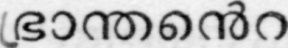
ഭ്രാന്തന്റെ
